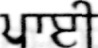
ਪਾਈ
